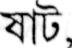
ষাট,
